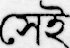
সেই
